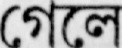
গেলে
